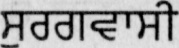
ਸੁਰਗਵਾਸੀ
